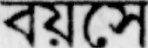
বয়সে
